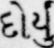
દોર્યું
